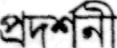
প্রদর্শনী
